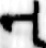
ન
